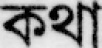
কথা
